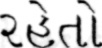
રહેતો
